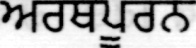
ਅਰਥਪੂਰਨ
